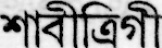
শাবীত্রিগী
